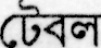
টেবল
